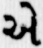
એ
